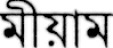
মীয়াম
